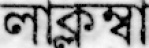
লাক্লম্বা
